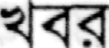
খবর
